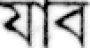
যাব
